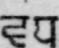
ਵਧ
